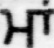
ਮਾਂ
